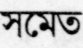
সমেত
